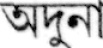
অদুনা
